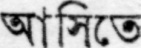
আসিতে
